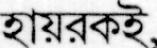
হায়রকই,
